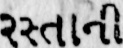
રસ્તાની
